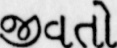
જીવતો
